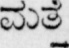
ಮತ್ತೆ
